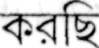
করছি
